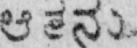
ಆತನು
